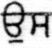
ਉਸ
